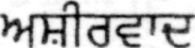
ਅਸ਼ੀਰਵਾਦ
